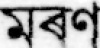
মৰণ
